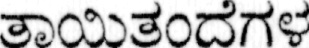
ತಾಯಿತಂದೆಗಳ
